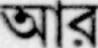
আর
